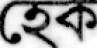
হেক
